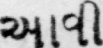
આવી
